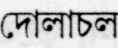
দোলাচল
